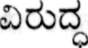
ವಿರುದ್ಧ
